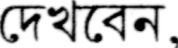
দেখবেন,
